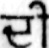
ਦੀ
